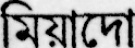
মিয়াদো
